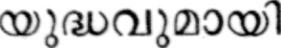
യുദ്ധവുമായി
